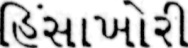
હિંસાખોરી
